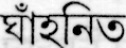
ঘাঁহনিত
